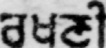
ਰਖਣੀ
